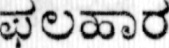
ಫಲಹಾರ
